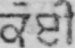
ਕੋਈ
